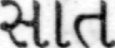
સાત
